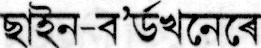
ছাইন-ব'র্ডখনেৰে
